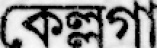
কেল্লগা
